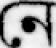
নে
